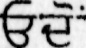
ਓਦੋਂ
